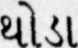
થોડા
